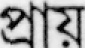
প্রায়
